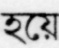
হয়ে
